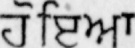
ਹੋਇਆ
